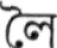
লৈ
